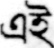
এই
